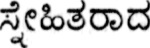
ಸ್ನೇಹಿತರಾದ
